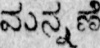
ಮನ್ನಣೆ
